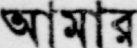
আমার
